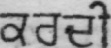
ਕਰਦੀ
